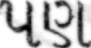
પણ
